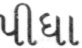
પીધા
